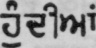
ਹੁੰਦੀਆਂ
